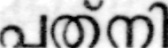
പത്നി
